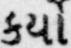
કર્યો
